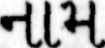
નામ
